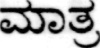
ಮಾತ್ರ
